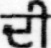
ਦੀ
